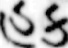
હક
